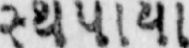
સ્થપાયા
